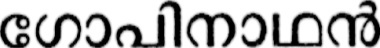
ഗോപിനാഥന്‍
